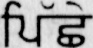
ਪਿੱਛੇ
